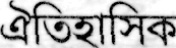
ঐতিহাসিক
